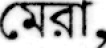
মেরা,
